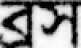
ব্রস
